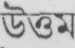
উত্তম
